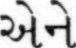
એને
